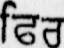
ਫਿਰ
